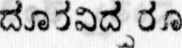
ದೂರವಿದ್ದರೂ
